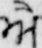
ਐ
